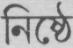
নিষ্ঠে
